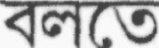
বলতে
